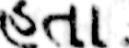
હતા.
